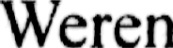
Weren
